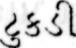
ટુકડી
